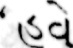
'હવે
